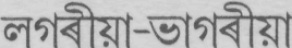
লগৰীয়া-ভাগৰীয়া
